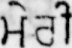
ਮੇਰੀ
